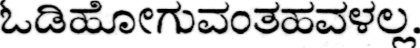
ಓಡಿಹೋಗುವಂತಹವಳಲ್ಲ.
